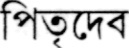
পিতৃদেব
